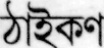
ঠাইকণ
